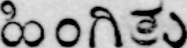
ಹಿಂಗಿತು
